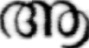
ആ
